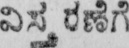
ವಿಸ್ತರಣೆಗೆ
